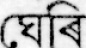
ঘেৰি
